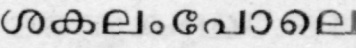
ശകലംപോലെ
